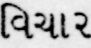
વિચાર
